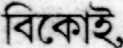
বিকোই,
